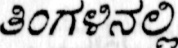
ತಿಂಗಳಿನಲ್ಲಿ
